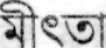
মীৎতা
